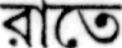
রাতে
